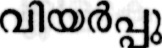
വിയര്‍പ്പു
